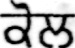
ਕੋਲ
